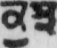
ਕੁਝ
